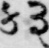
કરૂ
